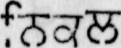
ਨਿਕਲ
